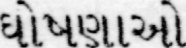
ઘોષણાઓ
